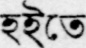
হইতে
